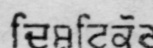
ਦ੍ਰਿਸ਼ਟਿਕੋਣ
